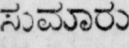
ಸುಮಾರು
